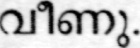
വീണു.
